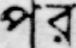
পর
